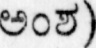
ಅಂಶ)
